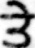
ਤੇ
